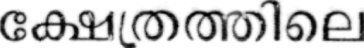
ക്ഷേത്രത്തിലെ
